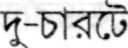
দু-চারটে
